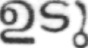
ഉടു
